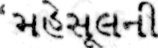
"મહેસૂલની
